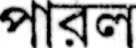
পারল
